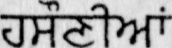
ਹਸੌਣੀਆਂ
